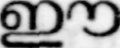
ഈ
